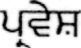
ਪ੍ਰਵੇਸ਼
